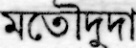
মতৌদুদা
